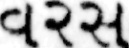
વરસ
